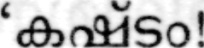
‘കഷ്ടം!
